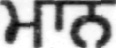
ਮਾਨ
